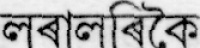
লৰালৰিকৈ
